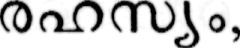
രഹസ്യം,
